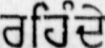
ਰਹਿੰਦੇ
